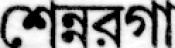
শেন্নরগা
